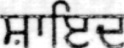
ਸ਼ਾਇਦ
